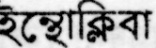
ইন্থোক্লিবা
